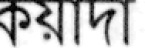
কয়াদা
